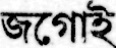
জগোই
